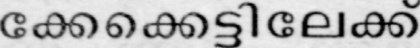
ക്കേക്കെട്ടിലേക്ക്
